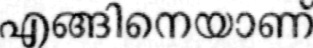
എങ്ങിനെയാണ്
